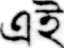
এই
